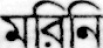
মরিনি
